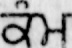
ਕੰਮ
